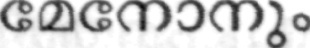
മേനോനും
